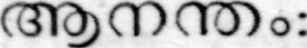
ആനന്തം:
